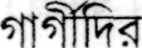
গার্গীদির
